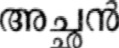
അച്ഛന്‍
